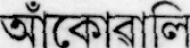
আঁকোৱালি
